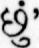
છું'
